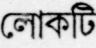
লোকটি
